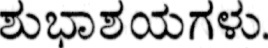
ಶುಭಾಶಯಗಳು.
